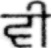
ਵੀ
